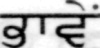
ਭਾਵੇਂ
